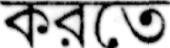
করতে
